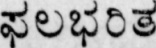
ಫಲಭರಿತ
